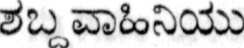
ಶಬ್ದವಾಹಿನಿಯು
